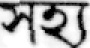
সহ্য
